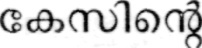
കേസിന്റെ
